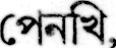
পেনখি,
